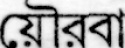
য়ৌরবা
